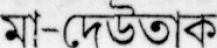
মা-দেউতাক
